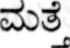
ಮತ್ತೆ
